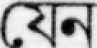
যেন
